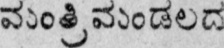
ಮಂತ್ರಿಮಂಡಲದ
